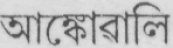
আঙ্কোৱালি
